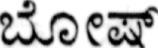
ಬೋಷ್
